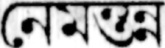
নেমন্তন্ন
